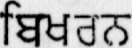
ਬਿਖਰਨ
